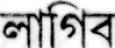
লাগিব
